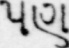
પણ
